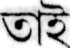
তাই
